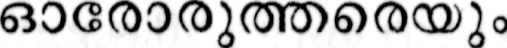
ഓരോരുത്തരെയും
